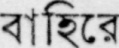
বাহিরে
